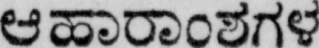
ಆಹಾರಾಂಶಗಳ
